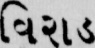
વિરાડ
